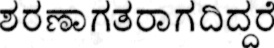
ಶರಣಾಗತರಾಗದಿದ್ದರೆ
